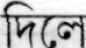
দিলে
